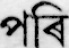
পৰি
